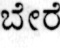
ಬೇರೆ
